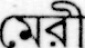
মেরী
